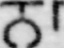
ਨਾ
